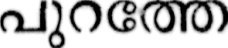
പുറത്തേ
